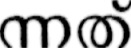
ന്നത്
